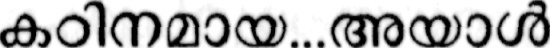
കഠിനമായ..അയാള്‍
